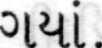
ગયાં.
